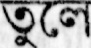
তুলে
